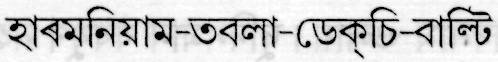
হাৰমনিয়াম-তবলা-ডেক্‌চি-বাল্টি
